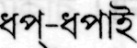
ধপ্-ধপাই
